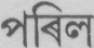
পৰিল
